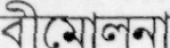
বীমোলনা
